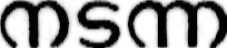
നടന്ന
